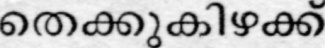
തെക്കുകിഴക്ക്
